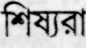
শিষ্যরা
